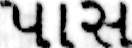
પાસ
